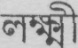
লক্ষ্মী
